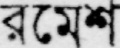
রমেশ
